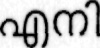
എനി
